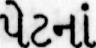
પેટનાં
